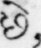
છે,
